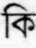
কি
